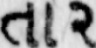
તાર
